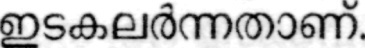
ഇടകലര്‍ന്നതാണ്.
